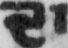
ਦਾ
